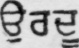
ਉਰਦੂ
